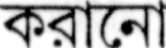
করানো
